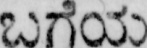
ಬಗೆಯ
